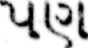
પણ
